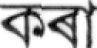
কৰা
